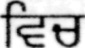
ਵਿਚ
